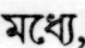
মধ্যে,
